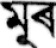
মূৰ
